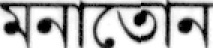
মনাতোন
